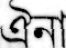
ঐনা
